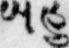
બહુ
